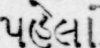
પહેલાં
